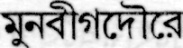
মুনবীগদৌরে
